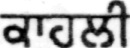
ਕਾਹਲੀ
